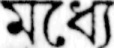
মধ্যে
